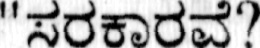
“ಸರಕಾರವೆ?
